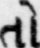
તો
